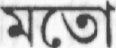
মতো
